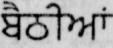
ਬੈਠੀਆਂ
